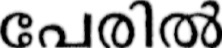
പേരില്‍
